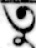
তু
